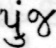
પુંજ
